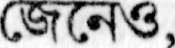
জেনেও,
